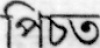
পিচত
